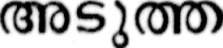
അടുത്ത
